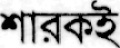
শারকই
